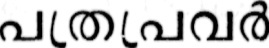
പത്രപ്രവര്‍
